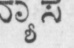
ವ್ಯಾಸ
